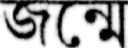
জন্মে
